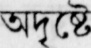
অদৃষ্টে
